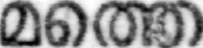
മത്തെ
